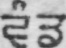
ਵੰਡ
